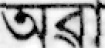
অৱা
